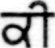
ਕੀ
